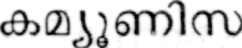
കമ്യൂണിസ
